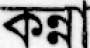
কন্না
